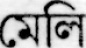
মেলি
